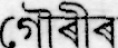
গৌৰীৰ
